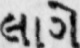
લાગે
